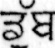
ਡੁੱਬ
